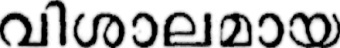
വിശാലമായ
